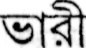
ভারী
